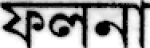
ফলনা
